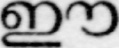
ഈ
